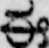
ಈ
